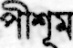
পীশূম
